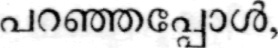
പറഞ്ഞപ്പോള്‍,
